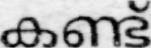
കണ്ട്
